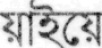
য়াইয়ে
